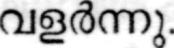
വളര്‍ന്നു.
